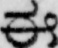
ಈ
